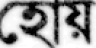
হোয়
